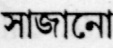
সাজানো
